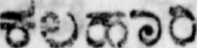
ಕಲಹಾರಿ
